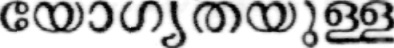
യോഗ്യതയുള്ള
